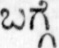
ಬಗ್ಗೆ
